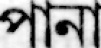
পানা
